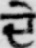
ਦੇ
